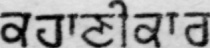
ਕਹਾਣੀਕਾਰ
